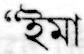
“ইমা
